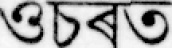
ওচৰত
